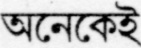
অনেকেই
